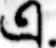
এ.
